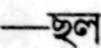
–ছল
